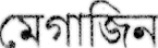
মেগাজিন
